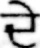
ਦੇ
